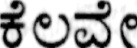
ಕೆಲವೇ
